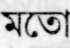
মতো
